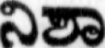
ನಿಶಾ
